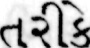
તરીકે
